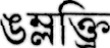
ঙম্লক্ত্রি
